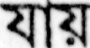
যায়
